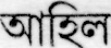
আহিল
